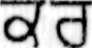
ਕਰ
